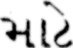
માટે
